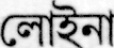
লোইনা
